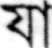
যা
